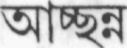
আচ্ছন্ন
